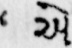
'એ
